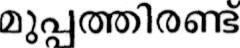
മുപ്പത്തിരണ്ട്
